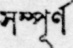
সম্পূর্ণ
